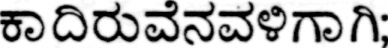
ಕಾದಿರುವೆನವಳಿಗಾಗಿ;
